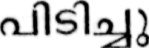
പിടിച്ചു
